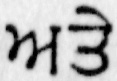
ਅਤੇ
